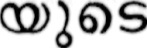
യുടെ
